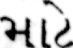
માટે
